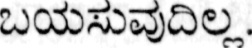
ಬಯಸುವುದಿಲ್ಲ.
